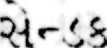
સેન્ડક
